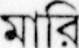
মারি
